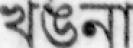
খঙনা
